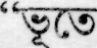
"ভূতে
